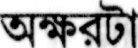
অক্ষরটা
